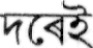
দৰেই
